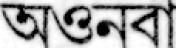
অওনবা
